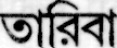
তারিবা
